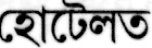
হোটেলত
